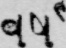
વર્ષ
